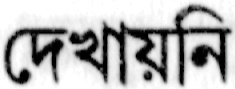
দেখায়নি
